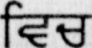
ਵਿਚ
